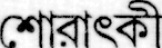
শোরাৎকী
